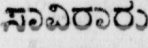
ಸಾವಿರಾರು
